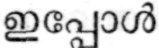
ഇപ്പോള്‍
